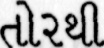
તોરથી
